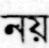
নয়
